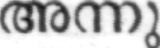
അന്നു
